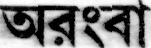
অরংবা
